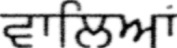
ਵਾਲਿਆਂ
